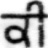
ਕੀ
